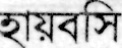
হায়বসি
